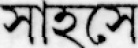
সাহসে
